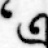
‘এ
